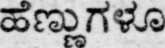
ಹೆಣ್ಣುಗಳೂ
